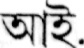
আই.
